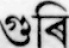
গুৰি
